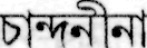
চান্দনীনা
